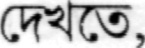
দেখতে,
